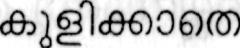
കുളിക്കാതെ
